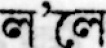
ল'লে
